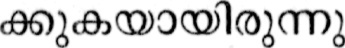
ക്കുകയായിരുന്നു
